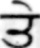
ਤੇ
